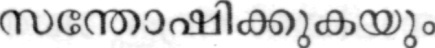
സന്തോഷിക്കുകയും
